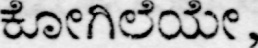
ಕೋಗಿಲೆಯೇ,
